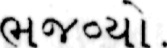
ભજવ્યો.
